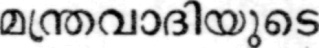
മന്ത്രവാദിയുടെ
